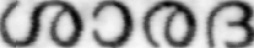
ശാരദ
